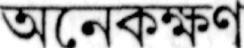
অনেকক্ষণ
